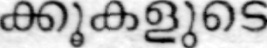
ക്കൂകളുടെ
